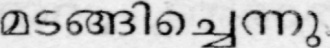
മടങ്ങിച്ചെന്നു.
